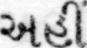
અહીં
